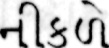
નીક
